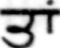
ਤਾਂ
